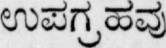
ಉಪಗ್ರಹವು
